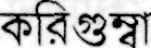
করিগুম্বা
